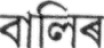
বালিৰ
